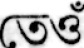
তেওঁ
